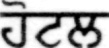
ਹੋਟਲ
